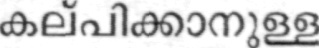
കല്പിക്കാനുള്ള
